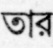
তার
